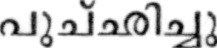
പുച്ഛിച്ചു
